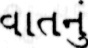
વાતનું
